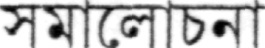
সমালোচনা
